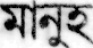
মানুহ
